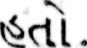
હતો.
